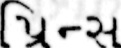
પ્રિન્સ
